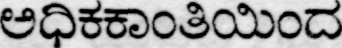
ಅಧಿಕಕಾಂತಿಯಿಂದ
